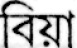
বিয়া
